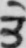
ਤੇ
